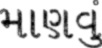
માણવું
